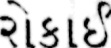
રોકાઈ
